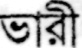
ভারী
